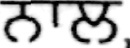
ਨਾਲ,
